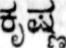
ಕೃಷ್ಣ
